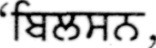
'ਬਿਲਸਨ,
